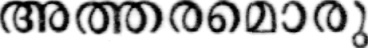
അത്തരമൊരു
